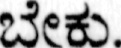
ಬೇಕು.
